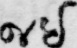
જઈ
